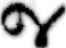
જ
